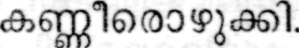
കണ്ണീരൊഴുക്കി.
